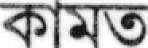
কামত
